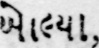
બોલ્યા,
